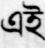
এই
